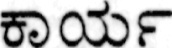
ಕಾರ್ಯ
